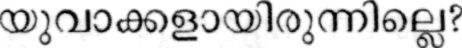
യുവാക്കളായിരുന്നില്ലെ?
